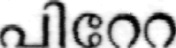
പിറേറ
